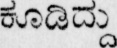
ಕೂಡಿದ್ದು
